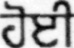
ਹੋਈ
